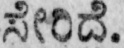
ಸೇರಿದೆ.
